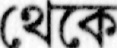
থেকে
